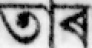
তাৰ
